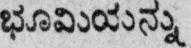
ಭೂಮಿಯನ್ನು
